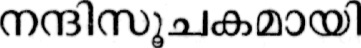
നന്ദിസൂചകമായി
